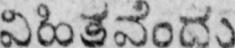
ವಿಹಿತವೆಂದು
